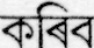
কৰিব
